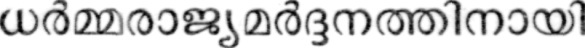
ധര്‍മ്മരാജ്യമര്‍ദ്ദനത്തിനായി
